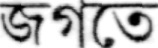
জগতে
